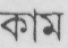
কাম
